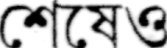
শেষেও
